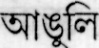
আঙুলি
